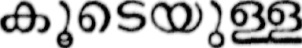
കൂടെയുള്ള
